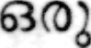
ഒരു
